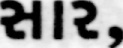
સાર,
